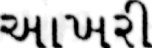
આખરી
